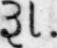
રૂ।.
